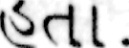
હતા.
